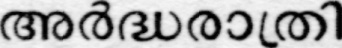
അര്‍ദ്ധരാത്രി
